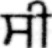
ਸੀ
